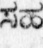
ಸಹ
